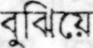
বুঝিয়ে
